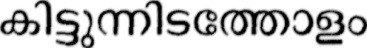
കിട്ടുന്നിടത്തോളം
